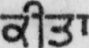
ਕੀਤਾ
